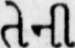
તેની
